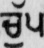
ਚੁੱਪ
